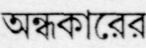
অন্ধকারের
